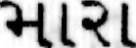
મારા
